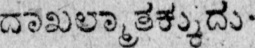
ದಾಖಲ್ಮಾತಕ್ಕುದು.
